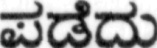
ಪಡೆದು
